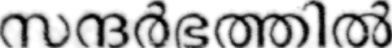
സന്ദര്‍ഭത്തില്‍
